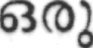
ഒരു
